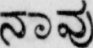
ನಾವು
